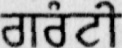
ਗਰੰਟੀ
